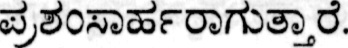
ಪ್ರಶಂಸಾರ್ಹರಾಗುತ್ತಾರೆ.
